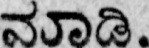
ಮಾಡಿ.
